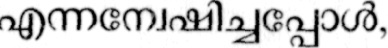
എന്നന്വേഷിച്ചപ്പോള്‍,
